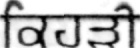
ਕਿਹੜੀ
